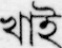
খাই
